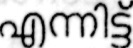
എന്നിട്ട്
